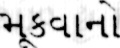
મૂકવાનો
